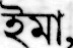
ইমা,
